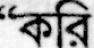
“করি
